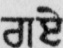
ਗਏ
